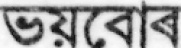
ভয়বোৰ
